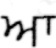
ਆ
